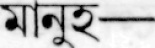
মানুহ-
